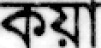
কয়া
